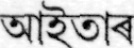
আইতাৰ
